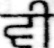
ਵੀ
